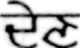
ਦੇਣ
